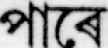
পাৰে
